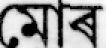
মোৰ
